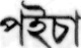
পইচা
